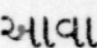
આવા
